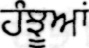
ਹੰਝੂਆਂ
